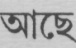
আছে
